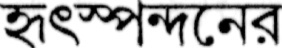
হৃত্স্পন্দনের
